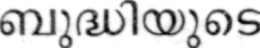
ബുദ്ധിയുടെ
